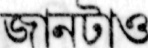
জানটাও
